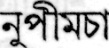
নুপীমচা
